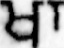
ਖਾ
